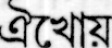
ঐখোয়
